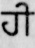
ਹੀ
